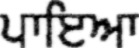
ਪਾਇਆ
